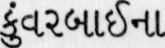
કુંવરબાઈના
